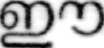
ഈ
